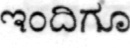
ಇಂದಿಗೂ
